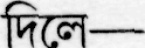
দিলে-
